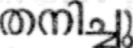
തനിച്ചു
